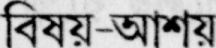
বিষয়-আশয়
